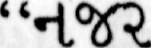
"નજર
